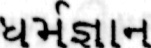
ધર્મજ્ઞાન
